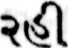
રહી
